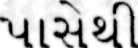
પાસેથી
